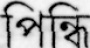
পিন্ধি
